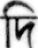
দি
